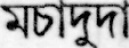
মচাদুদা
